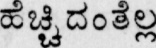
ಹೆಚ್ಚಿದಂತೆಲ್ಲ
